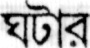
ঘটার
